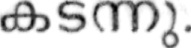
കടന്നു.
